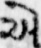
એ
